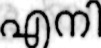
എനി
